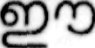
ഈ
